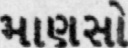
માણસો
